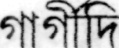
গার্গীদি
